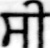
ਸੀ
